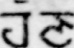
ਹੋਣ
